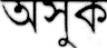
অসুক
